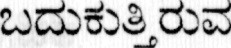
ಬದುಕುತ್ತಿರುವ
